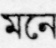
মনে
